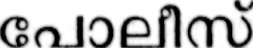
പോലീസ്
